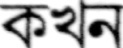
কখন
